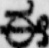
ಈ
